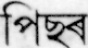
পিছৰ
